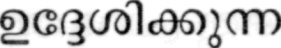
ഉദ്ദേശിക്കുന്ന
